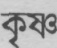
কৃষ্ণ
